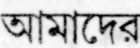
আমাদের
